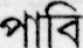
পাবি
